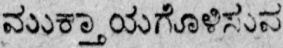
ಮುಕ್ತಾಯಗೊಳಿಸುವ
